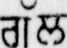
ਗੱਲ
